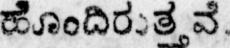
ಹೊಂದಿರುತ್ತವೆ.
